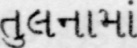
તુલનામાં
